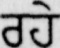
ਰਹੇ
